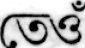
তেওঁ
